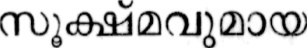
സൂക്ഷ്മവുമായ
